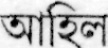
আহিল
